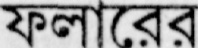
ফলারের
